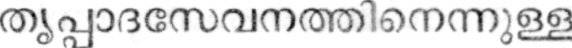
തൃപ്പാദസേവനത്തിനെന്നുള്ള
